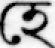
হে
